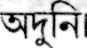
অদুনি।
